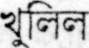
খুলিল
